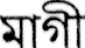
মাগী
